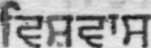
ਵਿਸ਼ਵਾਸ
